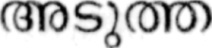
അടുത്ത
